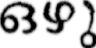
ഒഴു
